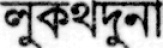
লুকথদুনা
